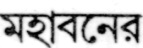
মহাবনের
